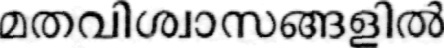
മതവിശ്വാസങ്ങളില്‍
